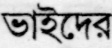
ভাইদের
